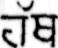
ਹੱਥ
